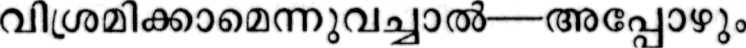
വിശ്രമിക്കാമെന്നുവച്ചാല്‍-അപ്പോഴും
